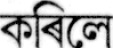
কৰিলে
